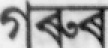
গৰুৰ
